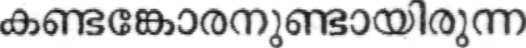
കണ്ടങ്കോരനുണ്ടായിരുന്ന
